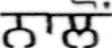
ਨਾਲੋਂ
